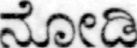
ನೋಡಿ
